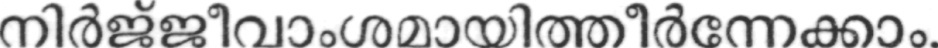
നിര്‍ജ്ജീവാംശമായിത്തീര്‍ന്നേക്കാം.
